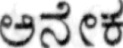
ಅನೇಕ
